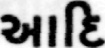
આદિ
